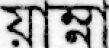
য়াম্না
